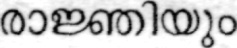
രാജ്ഞിയും
